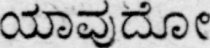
ಯಾವುದೋ
